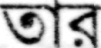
তার
